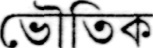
ভৌতিক
